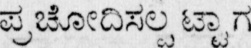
ಪ್ರಚೋದಿಸಲ್ಪಟ್ಟಾಗ
